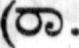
(ರಾ.
